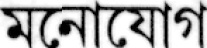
মনোযোগ
